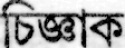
চিজ্ঞাক
